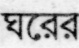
ঘরের
